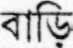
বাড়ি
